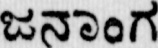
ಜನಾಂಗ
